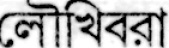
লৌখিবরা
